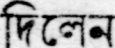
দিলেন
